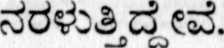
ನರಳುತ್ತಿದ್ದೇವೆ.
